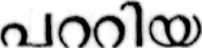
പററിയ
